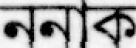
ননাক
